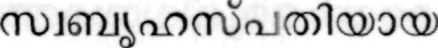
സ്വബൃഹസ്പതിയായ
